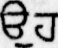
ਉਹ
